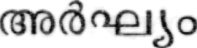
അര്‍ഘ്യം
